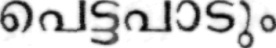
പെട്ടപാടും
